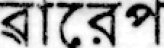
ৱারেপ
